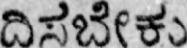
ದಿಸಬೇಕು
